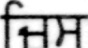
ਜਿਸ
